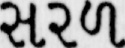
સરળ
